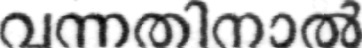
വന്നതിനാല്‍
